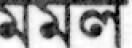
মমল
